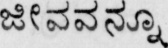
ಜೀವವನ್ನೂ
